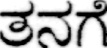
ತನಗೆ
